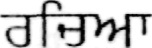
ਰਚਿਆ
